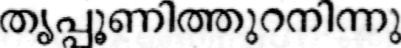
തൃപ്പൂണിത്തുറനിന്നു
